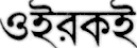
ওইরকই
